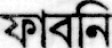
ফাবনি
